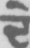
ਦੇ
